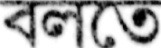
বলতে
